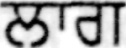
ਲਾਗ
